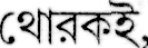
থোরকই,
